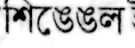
‘শিঙেঙেল
